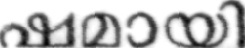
ഷമായി
